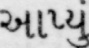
આપ્યું
